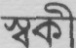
স্বকী
